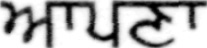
ਆਪਣਾ
